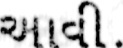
આવી.
